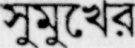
সুমুখের
